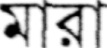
মারা
